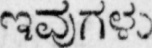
ಇವುಗಳು
